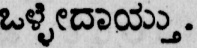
ಒಳ್ಳೇದಾಯ್ತು.
